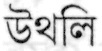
উথলি
